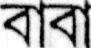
বাবা
